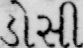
ડોસી
